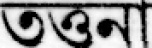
তত্তনা
